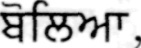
ਬੋਲਿਆ,
